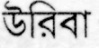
উরিবা
